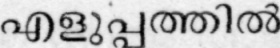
എളുപ്പത്തില്‍
